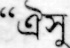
“ঐসু
